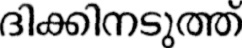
ദിക്കിനടുത്ത്
